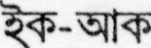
ইক-আক
